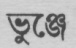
ভুঞ্জে
